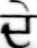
ਦੇ
